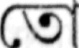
তো
